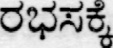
ರಭಸಕ್ಕೆ
